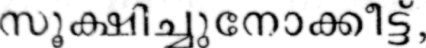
സൂക്ഷിച്ചുനോക്കീട്ട്,
